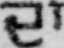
ਦਾ
